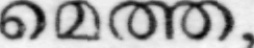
മെത്ത,
